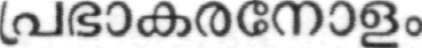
പ്രഭാകരനോളം
